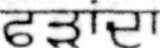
ਫੜਾਂਦਾ
